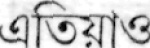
এতিয়াও
